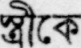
স্ত্রীকে
